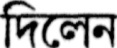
দিলেন
